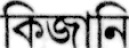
কিজানি
